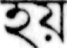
হয়
